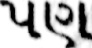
પણ
